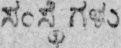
ಸಂಸ್ಥೆಗಳು
